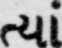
ત્યાં
